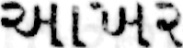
આખર
